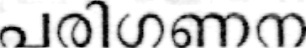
പരിഗണന
